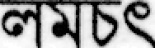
লমচৎ
